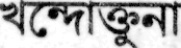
খন্দোক্তুনা
